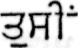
ਤੁਸੀਂ
